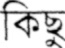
কিছু
